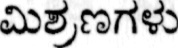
ಮಿಶ್ರಣಗಳು
